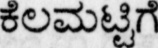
ಕೆಲಮಟ್ಟಿಗೆ
